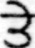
ਤੇ
